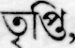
তৃপ্তি,
